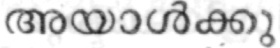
അയാള്‍ക്കു
